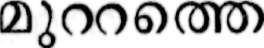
മുററത്തെ
